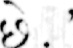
છે.'
